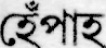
হেঁপাহ
